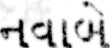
નવાબે
